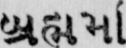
બ્રહ્મમાં
